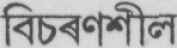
বিচৰণশীল
